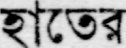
হাতের
